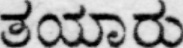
ತಯಾರು
